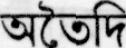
অতৈদি
